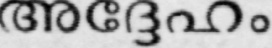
അദ്ദേഹം
